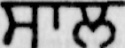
ਸਾਲ
